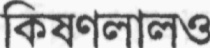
কিষণলালও
